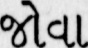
જોવા
